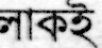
লাকই
